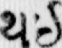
થઈ
